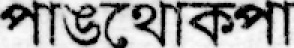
পাঙথোকপা
